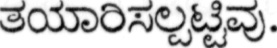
ತಯಾರಿಸಲ್ಪಟ್ಟಿವು.
